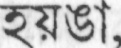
হয়ঙা,
